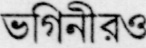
ভগিনীরও
